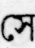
সে
